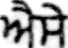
ਐਸੇ
